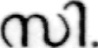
സി.
